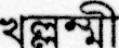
খল্লম্মী
